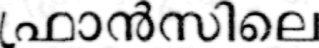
ഫ്രാന്‍സിലെ
